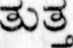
ತುತ್ತ
